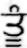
ਤੂੰ
